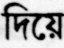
দিয়ে
